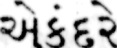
એકંદરે
